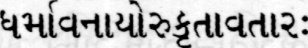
ધર્મવનાયોસ્કૃતાવતારઃ
